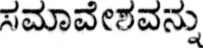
ಸಮಾವೇಶವನ್ನು
